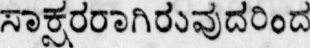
ಸಾಕ್ಷರರಾಗಿರುವುದರಿಂದ
